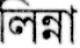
লিন্না
